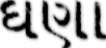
ઘણા
